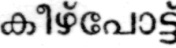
കീഴ്പോട്ട്
